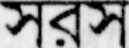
সরস
